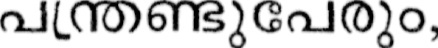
പന്ത്രണ്ടുപേരും,
